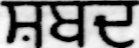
ਸ਼ਬਦ
